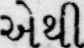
એથી
